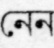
নেন
